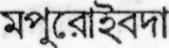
মপুরোইবদা
